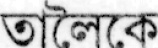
তালৈকে
